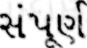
સંપૂર્ણ
